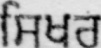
ਸਿਖਰ
